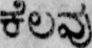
ಕೆಲವು
